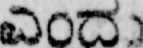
ಎಂದು
